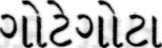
ગોટેગોટા
